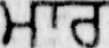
ਮਾਰ
